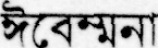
ঈবেম্মনা
